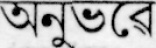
অনুভৱে
